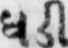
ઘડી
